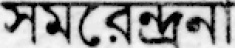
সমরেন্দ্রনা
